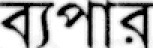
ব্যপার
